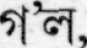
গ'ল,
